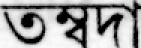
তম্বদা
